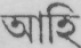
আহি
